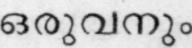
ഒരുവനും
